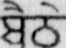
ਬੈਠੇ
